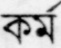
কর্ম
